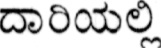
ದಾರಿಯಲ್ಲಿ
